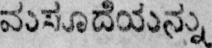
ಮಸೂದೆಯನ್ನು
